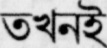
তখনই
